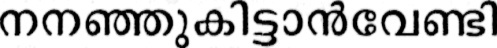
നനഞ്ഞുകിട്ടാന്‍വേണ്ടി
